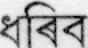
ধৰিব
